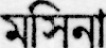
মসিনা
